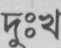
দুঃখ
